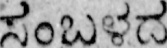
ಸಂಬಳದ
